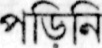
পড়িনি
